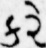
કરે
